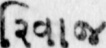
રિવાજ
